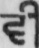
ਵੀ
